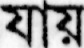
যায়
